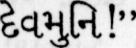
દેવમુનિ!"
